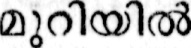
മുറിയില്‍
